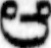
ಆ
